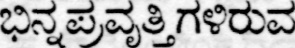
ಭಿನ್ನಪ್ರವೃತ್ತಿಗಳಿರುವ
